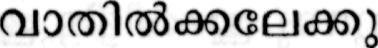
വാതില്‍ക്കലേക്കു
